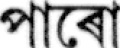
পাৰো
